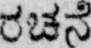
ರಚನೆ
